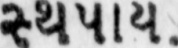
સ્થપાય.
